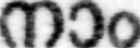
നാം
